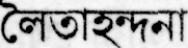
লৈতাহন্দনা
